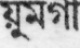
য়ুমগী
